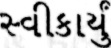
સ્વીકાર્યું
